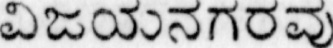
ವಿಜಯನಗರವು
